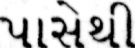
પાસેથી
